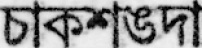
চাকশঙদা
